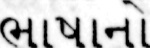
ભાષાનો
